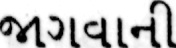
જાગવાની
